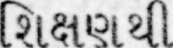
શિક્ષણથી
